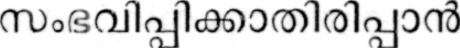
സംഭവിപ്പിക്കാതിരിപ്പാന്‍
